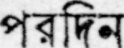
পরদিন
